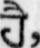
ਹੈ,
